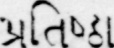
પ્રતિષ્ઠા
